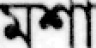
মশা
